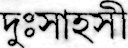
দুঃসাহসী
